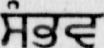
ਸੰਭਵ
